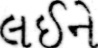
લઈને
